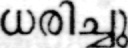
ധരിച്ചു
